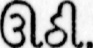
ઊઠી.
